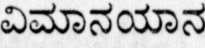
ವಿಮಾನಯಾನ
